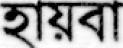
হায়বা
